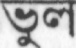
ভুল
